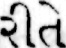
રીતે
